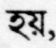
হয়,
